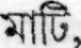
মাটি,
